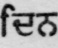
ਦਿਨ
